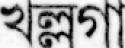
খল্লগা
